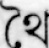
থৈ
